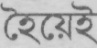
হৈয়েই
